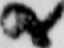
જ
